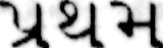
પ્રથમ
